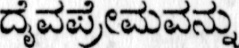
ದೈವಪ್ರೇಮವನ್ನು
